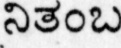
ನಿತಂಬ
